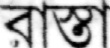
রাস্তা
